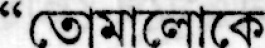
"তোমালোকে
